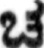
ಚ
